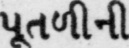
પૂતળીની
